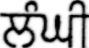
ਲੰਘੀ
